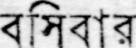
বসিবার
